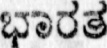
ಭಾರತ
